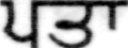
ਪਤਾ
